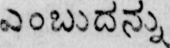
ಎಂಬುದನ್ನು
